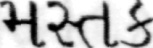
મસ્તક
